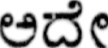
ಅದೇ
